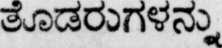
ತೊಡರುಗಳನ್ನು
